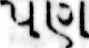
પણ
